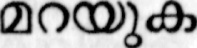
മറയുക
